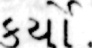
કર્યો.
